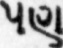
પણ
